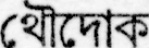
থৌদোক
